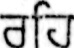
ਰਹਿ
